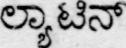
ಲ್ಯಾಟಿನ್
